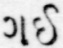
ગઈ
